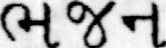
ભજન
